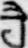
ਹੈ
